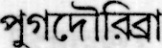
পুগদৌরিব্রা
